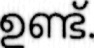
ഉണ്ട്.
